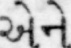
એને
